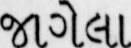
જાગેલા
